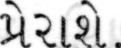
પ્રેરાશે.
